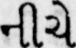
નીચે
